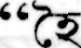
“হৈ
